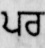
ਪਰ
